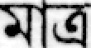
মাত্র
